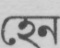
হেন
